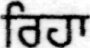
ਰਿਹਾ
